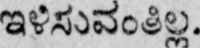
ಇಳಿಸುವಂತಿಲ್ಲ.
